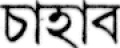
চাহাব
